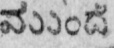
ಮುಂದೆ
